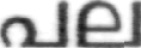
പല
